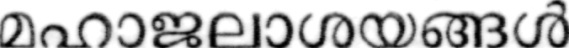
മഹാജലാശയങ്ങള്‍
